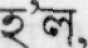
হ'ল,
